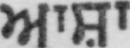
ਆਸ਼ਾ
